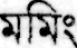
মমিং
